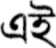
এই
